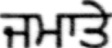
ਜਮਾਤੇ
